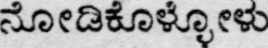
ನೋಡಿಕೊಳ್ಳೋಳು
